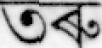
তৰু
